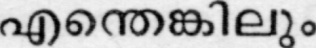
എന്തെങ്കിലും
